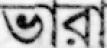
ভারা
